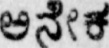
ಅನೇಕ
